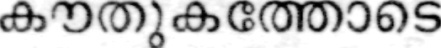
കൌതുകത്തോടെ
